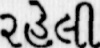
રહેલી
